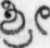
ಶ್ರೀ
